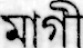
মাগী
